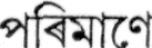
পৰিমাণে
